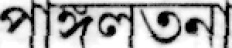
পাঙ্গলতনা
